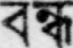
বন্ধ
